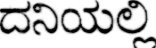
ದನಿಯಲ್ಲಿ
